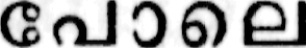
പോലെ
